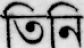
তিনি
